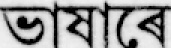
ভাষাৰে
